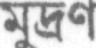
মুদ্রণ
